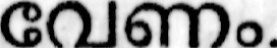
വേണം.
